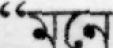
"মনে
